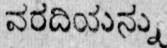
ವರದಿಯನ್ನು
